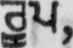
ਰੂਪ,
